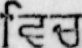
ਵਿਚ
